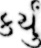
કર્યું
